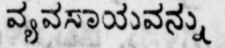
ವ್ಯವಸಾಯವನ್ನು
